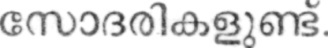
സോദരികളുണ്ട്.
